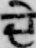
ਦੇ
